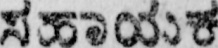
ಸಹಾಯಕ
